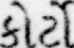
કોર્ટો
